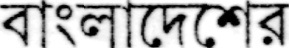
বাংলাদেশের
